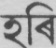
হৰি
